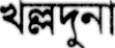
খল্লদুনা
